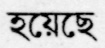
হয়েছে
